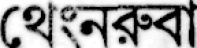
থেংনরুবা
